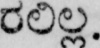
ರಲಿಲ್ಲ.
